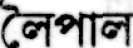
লৈপাল
